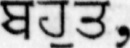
ਬਹੁਤ,
